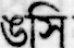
ঙসি
